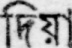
দিয়া
